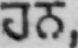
ਹਨ,
